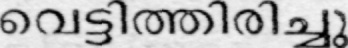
വെട്ടിത്തിരിച്ചു
